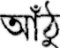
আঁঠু
